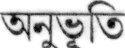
অনুভূতি
